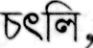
চৎলি,
